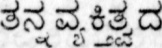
ತನ್ನವ್ಯಕ್ತಿತ್ವದ
